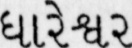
ધારેશ્વર
